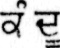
ਕੰਦੂ
